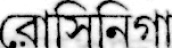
রোসিনিগা
